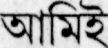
আমিই
